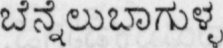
ಬೆನ್ನೆಲುಬಾಗುಳ್ಳ
